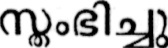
സ്തംഭിച്ചു
